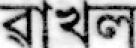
ৱাখল
